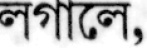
লগালে,
